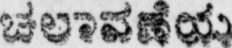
ಚಲಾವಣೆಯ
